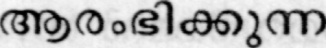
ആരംഭിക്കുന്ന
